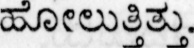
ಹೋಲುತ್ತಿತ್ತು.
